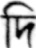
দি
